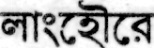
লাংহৌরে
